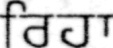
ਰਿਹਾ
